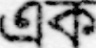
এক
